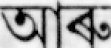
আৰু
